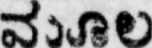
ಮೂಲ
